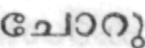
ചോറു
